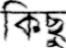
কিছু
